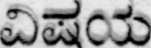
ವಿಷಯ
